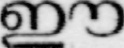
ഈ
